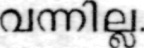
വന്നില്ല.
